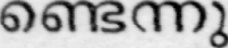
ണ്ടെന്നു
